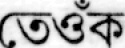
তেওঁক
